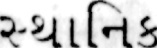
સ્થાનિક
